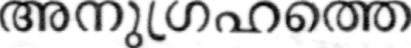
അനുഗ്രഹത്തെ
